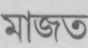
মাজত
